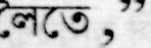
লৈতে,”
